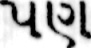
પણ
